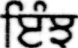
ਇੰਝ
